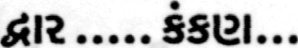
દ્વાર........કંકણ...
